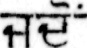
ਜਦੋਂ
